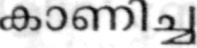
കാണിച്ച
